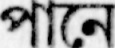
পানে
